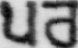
ਪਰ
